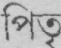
পিতৃ
